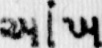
આંખ
